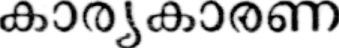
കാര്യകാരണ
